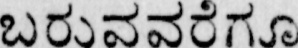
ಬರುವವರೆಗೂ
